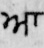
ਆ
